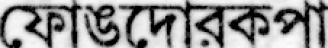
ফোঙদোরকপা
